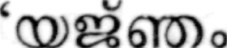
'യജ്ഞം
